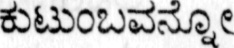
ಕುಟುಂಬವನ್ನೋ
